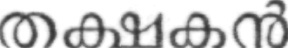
തക്ഷകന്‍
